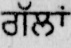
ਗੱਲਾਂ
